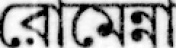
রোমেন্না
